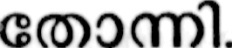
തോന്നി.
